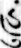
હું
